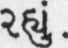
રહ્યું.
